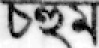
চহুম
